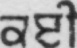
ਕਈ
